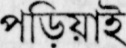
পড়িয়াই
